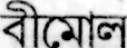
বীমোল
